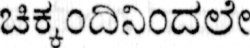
ಚಿಕ್ಕಂದಿನಿಂದಲೇ
